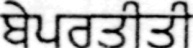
ਬੇਪਰਤੀਤੀ
